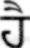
ਹੈ
